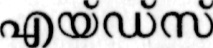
എയ്ഡ്സ്
